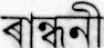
ৰান্ধনী
